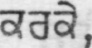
ਕਰਕੇ,
